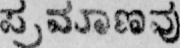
ಪ್ರಮಾಣವು
